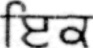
ਇਕ
